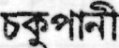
চকুপানী
